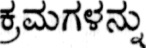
ಕ್ರಮಗಳನ್ನು
